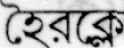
হৈরক্লে
